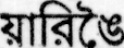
য়ারিঙৈ
